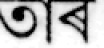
তাৰ
